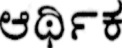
ಆರ್ಥಿಕ
